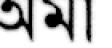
অমা
